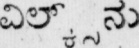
ವಿಲ್ಕ್ಸ್‌ನು
